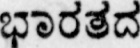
ಭಾರತದ
